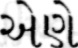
એણે
